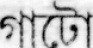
গাটো
